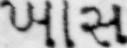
ખાસ
